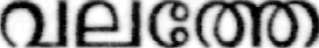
വലത്തേ
